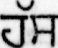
ਹੱਸ
